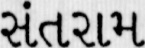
સંતરામ
